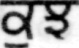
ਕੁਝ
